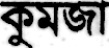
কুমজা
